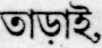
তাড়াই,
